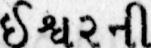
ઈશ્વરની
